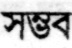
সম্ভব
